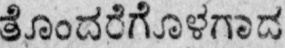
ತೊಂದರೆಗೊಳಗಾದ
